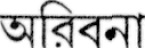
অরিবনা
